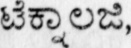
ಟೆಕ್ನಾಲಜಿ,
